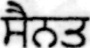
ਸੈਨਤ
